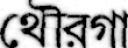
থৌরগা
